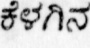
ಕೆಳಗಿನ
